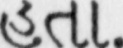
હતા.
